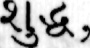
શુદ્ધ,
